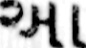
આ
